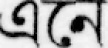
এনে
